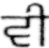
ਵੀ
